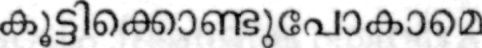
കൂട്ടിക്കൊണ്ടുപോകാമെ
